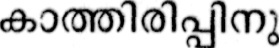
കാത്തിരിപ്പിനു
